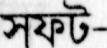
সফট-
